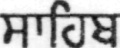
ਸਾਹਿਬ
